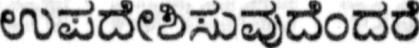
ಉಪದೇಶಿಸುವುದೆಂದರೆ
